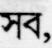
সব,
